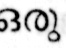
ഒരു
